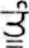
ਤੂੰ
